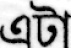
এটা
